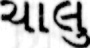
ચાલુ
